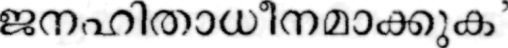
ജനഹിതാധീനമാക്കുക'
